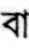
বা
